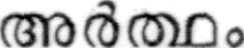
അര്‍ത്ഥം
